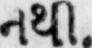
નથી.
